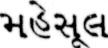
મહેસૂલ
